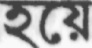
হয়ে
